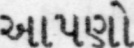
આપણો
